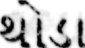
થોડા
